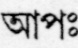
আপঃ
